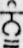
ਨੂੰ
